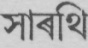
সাৰথি
